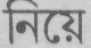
নিয়ে
